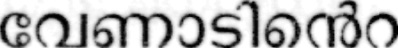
വേണാടിന്റെ
